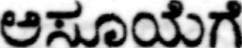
ಅಸೂಯೆಗೆ
